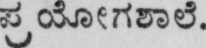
ಪ್ರಯೋಗಶಾಲೆ,
